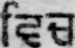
ਵਿਚ
